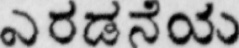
ಎರಡನೆಯ
